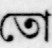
তো
